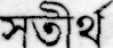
সতীর্থ
